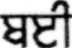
ਬਈ
